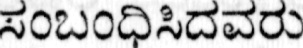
ಸಂಬಂಧಿಸಿದವರು
